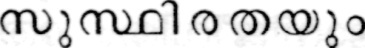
സുസ്ഥിരതയും
